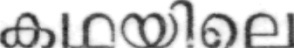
കഥയിലെ
